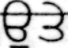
ਉਤੇ
